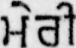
ਮੇਰੀ
